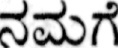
ನಮಗೆ
